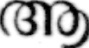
ആ
